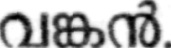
വങ്കന്‍.
